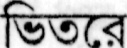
ভিতরে
